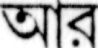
আর
